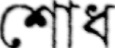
শোধ
